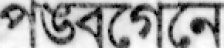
পঙবগেনে
